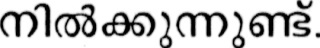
നില്‍ക്കുന്നുണ്ട്.
